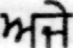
ਅਜੇ
